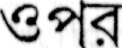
ওপর
